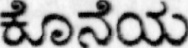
ಕೊನೆಯ
